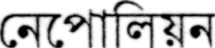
নেপোলিয়ন
